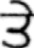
ਤੇ
